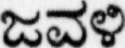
ಜವಳಿ
